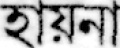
হায়না
